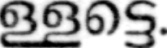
ള്ളട്ടെ.
